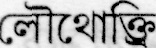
লৌথোক্ত্রি
